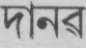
দানৱ
